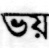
ভয়
